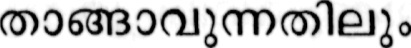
താങ്ങാവുന്നതിലും
